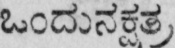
ಒಂದುನಕ್ಷತ್ರ
